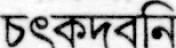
চৎকদবনি
